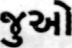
જુઓ
